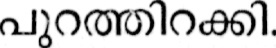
പുറത്തിറക്കി.
